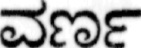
ವರ್ಣ
